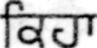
ਕਿਹਾ
